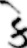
કે
